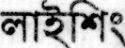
লাইশিং
